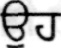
ਉਹ
